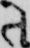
તે
